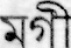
মগী
